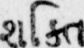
શક્તિ
